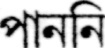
পাননি
